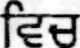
ਵਿਚ
